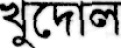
খুদোল
